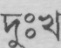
দুঃখ
